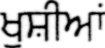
ਖੁਸ਼ੀਆਂ
